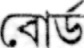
বোর্ড
